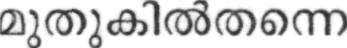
മുതുകില്‍തന്നെ
